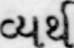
વ્યર્થ
